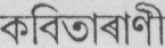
কবিতাৰাণী
